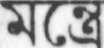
মন্ত্রে
